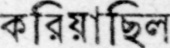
করিয়াছিল
